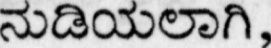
ನುಡಿಯಲಾಗಿ,
